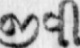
જીવી
